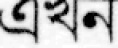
এখন
